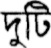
দুটি
